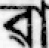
ৱা
